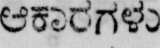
ಆಕಾರಗಳು
